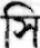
সি
